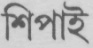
শিপাই
